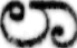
ಲಾ
